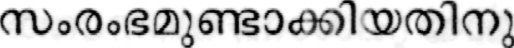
സംരംഭമുണ്ടാക്കിയതിനു
